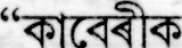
"কাবেৰীক
